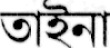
তাইনা
